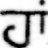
ਹਾਂ
